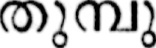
തുമ്പു
